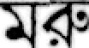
মরু
